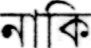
নাকি
